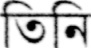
তিনি
